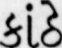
કાંઠે
